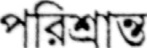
পরিশ্রান্ত
